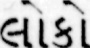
લોકો
